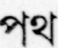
পথ
